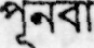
পূনবা
